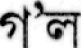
গ'ল
